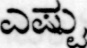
ಎಷ್ಟು
